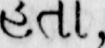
હતા,
